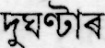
দুঘণ্টাৰ
